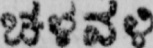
ಚಳವಳಿ
